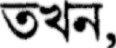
তখন,
